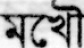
মখৌ
